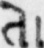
તો
